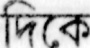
দিকে
